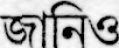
জানিও
